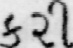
કરી
